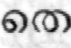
തെ
